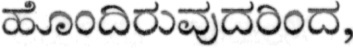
ಹೊಂದಿರುವುದರಿಂದ,
